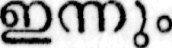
ഇന്നും
